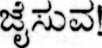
ಜೈಸುವ!
